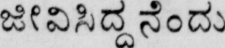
ಜೀವಿಸಿದ್ದನೆಂದು
